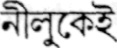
নীলুকেই
